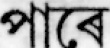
পাৰে
